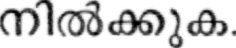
നില്‍ക്കുക.
